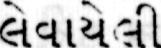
લેવાયેલી
